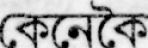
কেনেকৈ
